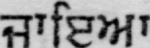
ਜਾਇਆ
